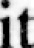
it
